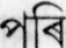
পৰি
